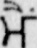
ਮੈਂ
